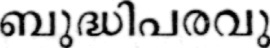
ബുദ്ധിപരവു
